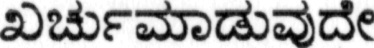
ಖರ್ಚುಮಾಡುವುದೇ
